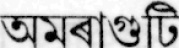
অমৰাগুটি
